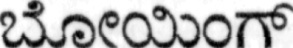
ಬೋಯಿಂಗ್
